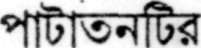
পাটাতনটির
